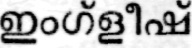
ഇംഗ്ളീഷ്
